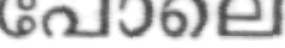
പോലെ
